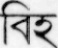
বিহ
